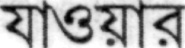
যাওয়ার
